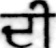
ਦੀ
